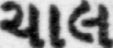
ચાલ
